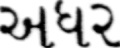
અધર
